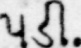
પડી.
